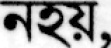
নহয়,
